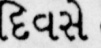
દિવસે
